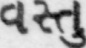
વસ્તુ
